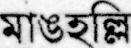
মাঙহল্লি
